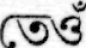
তেওঁ
